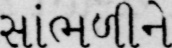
સાંભળીને
